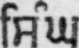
ਸਿੰਘ
